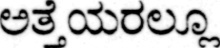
ಅತ್ತೆಯರಲ್ಲೂ
